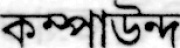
কম্পাউন্দ
